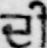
ਦੀ
